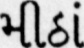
મીઠાં
